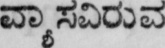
ವ್ಯಾಸವಿರುವ
